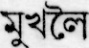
মুখলৈ
